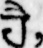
ਹੈ,
